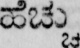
ಹೆಚ್ಚು
